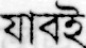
যাবই
